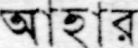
আহার
